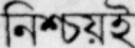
নিশ্চয়ই
